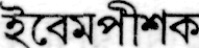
ইবেমপীশক
